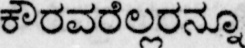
ಕೌರವರೆಲ್ಲರನ್ನೂ
